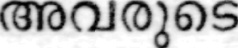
അവരുടെ
